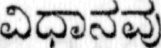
ವಿಧಾನವು
